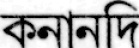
কনানদি
